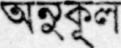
অনুকূল
